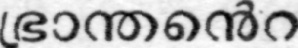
ഭ്രാന്തന്റെ
